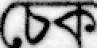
চেক
